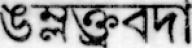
ঙম্লক্ত্রবদা
